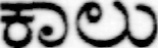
ಕಾಲು
